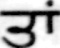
ਤਾਂ
